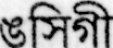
ঙসিগী
